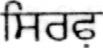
ਸਿਰਫ਼
